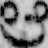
ಆ
